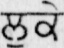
ਲੁਕੇ
